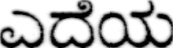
ಎದೆಯ
